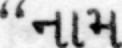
“નામ
